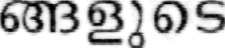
ങ്ങളുടെ
